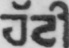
ਹੱਟੀ
